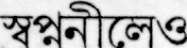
স্বপ্ননীলেও
